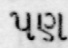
પણ
